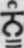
ਨੂੰ
